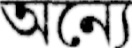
অন্যে
